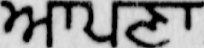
ਆਪਣਾ
